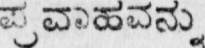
ಪ್ರವಾಹವನ್ನು
